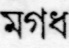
মগধ
